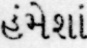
હંમેશાં
